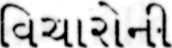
વિચારોની
